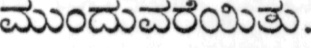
ಮುಂದುವರೆಯಿತು.
